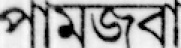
পামজবা
